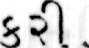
કરી.
